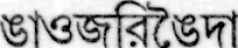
ঙাওজরিঙৈদা
